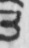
ਤੇ
